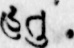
હતું.
